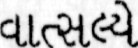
વાત્સલ્યે
